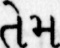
તેમ
